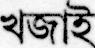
খজাই
